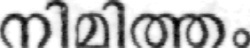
നിമിത്തം
